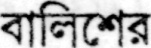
বালিশের
